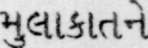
મુલાકાતને
